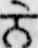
ਨੇ
